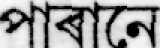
পাৰানে
